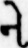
ને
